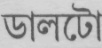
ডালটো
